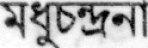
মধুচন্দ্রনা
